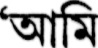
'আমি
